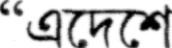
“এদেশে
